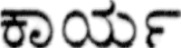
ಕಾರ್ಯ
